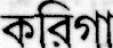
করিগা
